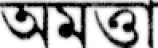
অমত্তা
